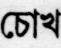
চোখ
